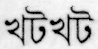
খটখট
